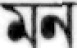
মন
